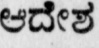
ಆದೇಶ
